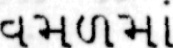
વમળમાં
